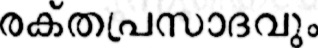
രക്തപ്രസാദവും
